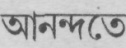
আনন্দতে
